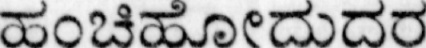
ಹಂಚಿಹೋದುದರ
